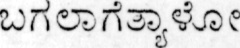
ಬಗಲಾಗೆತ್ಯಾಳೋ
